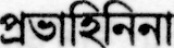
প্রভাহিনিনা
